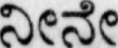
ನೀನೇ
